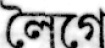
লৈগে
